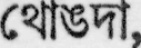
থোঙদা,
